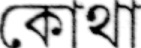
কোথা
